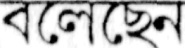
বলেছেন
